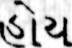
હોય
